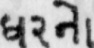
ધરનો
